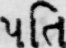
પતિ
